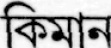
কিমান
